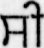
ਸੀ
